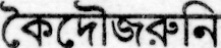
কৈদৌজরুনি
